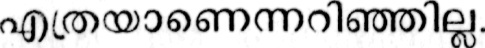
എത്രയാണെന്നറിഞ്ഞില്ല.
